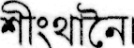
শীংথানৈ।
